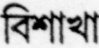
বিশাখা
